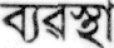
ব্যৱস্থা
